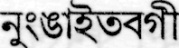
নুংঙাইতপগী
